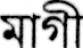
মাগী
